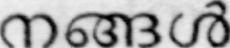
നങ്ങള്‍
